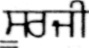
ਸੂਰਜੀ
